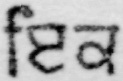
ਇਕ
